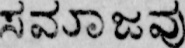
ಸಮಾಜವು
